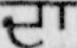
ਦਾ
